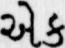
એક
